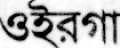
ওইরগা
